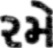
રમે
